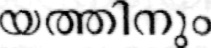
യത്തിനും
